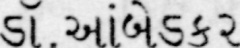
ડૉ.આંબેડકર
